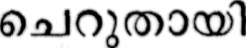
ചെറുതായി
